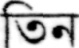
তিন
